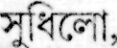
সুধিলো,
